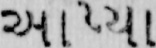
આપ્યા
